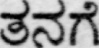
ತನಗೆ
